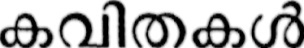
കവിതകള്‍
